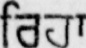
ਰਿਹਾ
